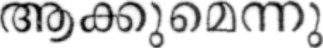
ആക്കുമെന്നു
